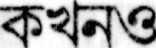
কখনও
